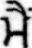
ਮੈਂ
